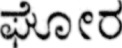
ಘೋರ
